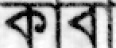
কাবা
